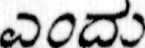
ಎಂದು
